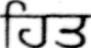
ਹਿਤ
